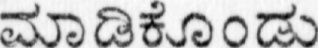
ಮಾಡಿಕೊಂಡು
